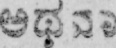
ಅಥವಾ
